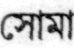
সোমা
